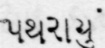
પથરાયું
